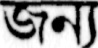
জন্য
